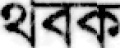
থবক
